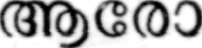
ആരോ
